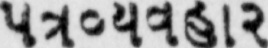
પત્રવ્યવહાર
